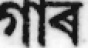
গাৰ
